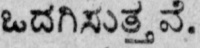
ಒದಗಿಸುತ್ತವೆ.
